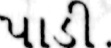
પાડી.
